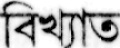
বিখ্যাত
